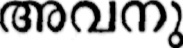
അവനു
